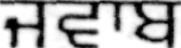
ਜਵਾਬ
